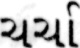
ચર્ચા
